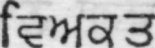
ਵਿਅਕਤ
